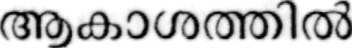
ആകാശത്തില്‍
